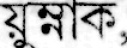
য়ুম্নাক,
